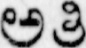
ಅತಿ
